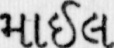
માઈલ
